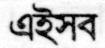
এইসব
